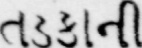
તડકાની
